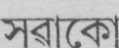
সৱাকো
